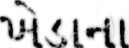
ખેડાના
